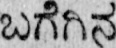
ಬಗೆಗಿನ
